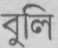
বুলি
